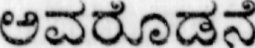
ಅವರೊಡನೆ
